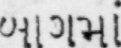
બાગમાં
